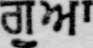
ਗੁਆ
